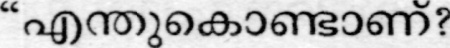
"എന്തുകൊണ്ടാണ്?
